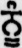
ਨੂੰ
